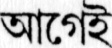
আগেই
